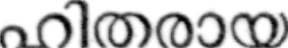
ഹിതരായ
